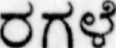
ರಗಳೆ
